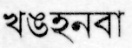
খঙহনবা
